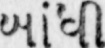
બાંધી
